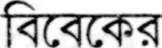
বিবেকের
